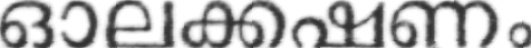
ഓലക്കഷണം
